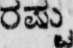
ರಷ್ಟು
